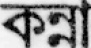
কন্না
